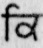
ਕਿ
